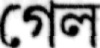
গেল
